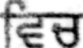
ਵਿਚ
